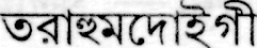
তরাহুমদোইগী
